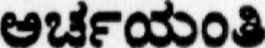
ಅರ್ಚಯಂತಿ
